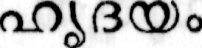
ഹൃദയം
